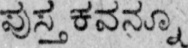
ಪುಸ್ತಕವನ್ನೂ
